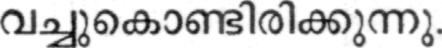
വച്ചുകൊണ്ടിരിക്കുന്നു.
